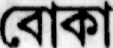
বোকা
